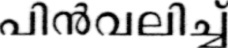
പിന്‍വലിച്ച്
